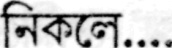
নিকলে....
